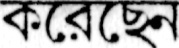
করেছেন
